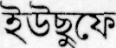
ইউছুফে
